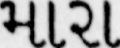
મારા
